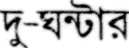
দু-ঘন্টার
